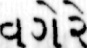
વગેરે
